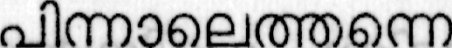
പിന്നാലെത്തന്നെ
